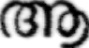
ആ
